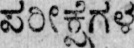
ಪರೀಕ್ಷೆಗಳ
